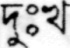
দুঃখ
